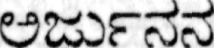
ಅರ್ಜುನನ
